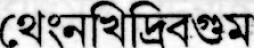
থেংনখিদ্রিবগুম
